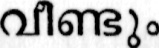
വീണ്ടും
